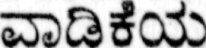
ವಾಡಿಕೆಯ
